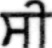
ਸੀ
